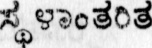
ಸ್ಥಳಾಂತರಿತ
